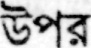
উপর
